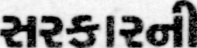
સરકારની
